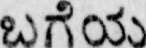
ಬಗೆಯ
